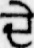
ਦੇ
